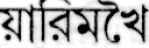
য়ারিমখৈ
